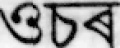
ওচৰ
